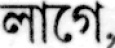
লাগে,
